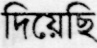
দিয়েছি
